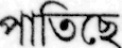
পাতিছে
